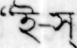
"ই-স্
